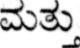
ಮತ್ತು
